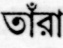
তাঁরা
